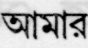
আমার
